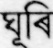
ঘূৰি
